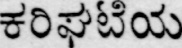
ಕರಿಘಟೆಯ
